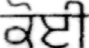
ਕੋਈ
